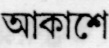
আকাশে
